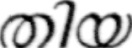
തിയ
